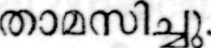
താമസിച്ചു.
